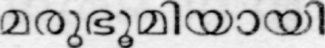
മരുഭൂമിയായി
